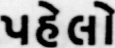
પહેલો
